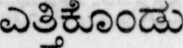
ಎತ್ತಿಕೊಂಡು
